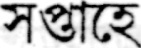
সপ্তাহে
